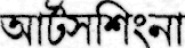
আর্টসশিংনা
